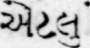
એટલું
